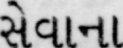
સેવાના
